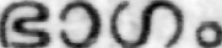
ഭാഗം
